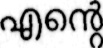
എന്റെ
